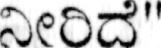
ನೀರಿದೆ”
